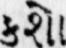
કશો
